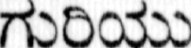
ಗುರಿಯು
